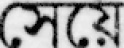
সেয়ে
